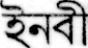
ইনবী
